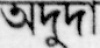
অদুদা
